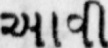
આવી
